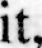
it,
